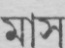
মাস
